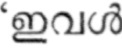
‘ഇവള്‍
